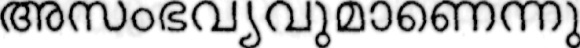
അസംഭവ്യവുമാണെന്നു
